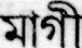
মাগী
